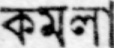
কমলা
